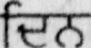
ਦਿਨ
